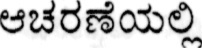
ಆಚರಣೆಯಲ್ಲಿ
